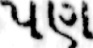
પણ
